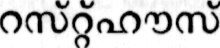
റസ്റ്റ്ഹൌസ്
